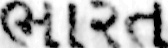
ભારત
